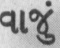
વાજું
